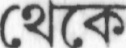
থেকে
